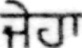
ਜੇਹਾ
